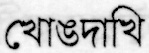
খোঙদাখি
